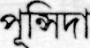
পূন্সিদা
